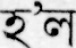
হ'ল
